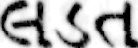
લડત
